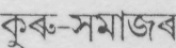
কুৰু-সমাজৰ
